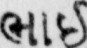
ભાઈ
